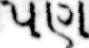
પણ
